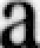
a
